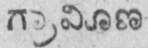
ಗ್ರಾಮೀಣ
